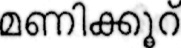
മണിക്കൂറ്
